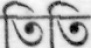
তিতি
